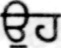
ਉਹ
